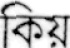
কিয়
